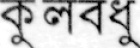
কুলবধু
